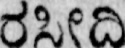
ರಸೀದಿ
